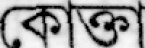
কোক্তা
